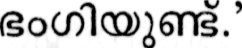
ഭംഗിയുണ്ട്.’
